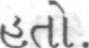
હતો.
